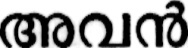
അവന്‍
